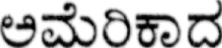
ಅಮೆರಿಕಾದ
